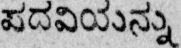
ಪದವಿಯನ್ನು
